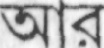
আর
